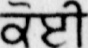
ਕੋਈ
